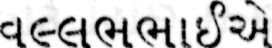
વલ્લભભાઈએ
